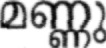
മണ്ണു
